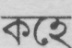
কহে
